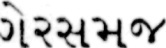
ગેરસમજ
